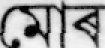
মোৰ
